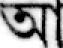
আ
